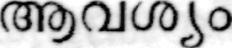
ആവശ്യം
